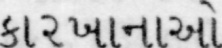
કારખાનાઓ
